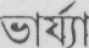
ভাৰ্য্যা
